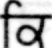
ਕਿ
